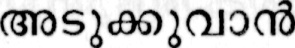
അടുക്കുവാന്‍
